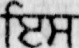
ਇਸ
